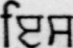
ਇਸ
